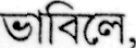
ভাবিলে,
